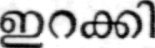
ഇറക്കി
